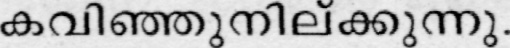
കവിഞ്ഞുനില്ക്കുന്നു.
